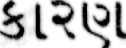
કારણ
